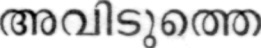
അവിടുത്തെ
